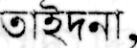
তাইদনা,
